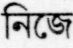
নিজে
